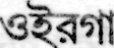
ওইরগা
